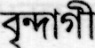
বৃন্দাগী
